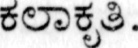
ಕಲಾಕೃತಿ.
